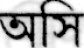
অসি
